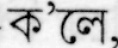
ক'লে,
